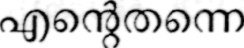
എന്റെതന്നെ
